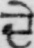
ਦੇ
